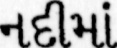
નદીમાં
